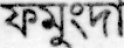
ফমুংদা
